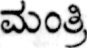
ಮಂತ್ರಿ
